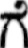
ಗೆ
